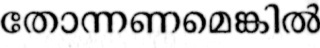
തോന്നണമെങ്കില്‍
